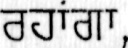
ਰਹਾਂਗਾ,
